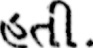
હતી.
